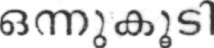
ഒന്നുകൂടി
